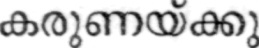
കരുണയ്ക്കു
